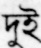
দুই
